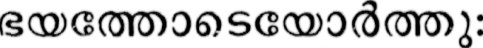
ഭയത്തോടെയോര്‍ത്തു:
